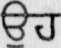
ਉਹ
